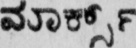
ಮಾರ್ಕ್ಸ್
